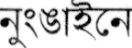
নুংঙাইনে
